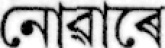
নোৱাৰে
